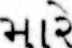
મારે
